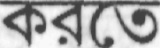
করতে
